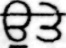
ਉਤੇ
